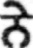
ਨੇ
